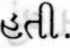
હતી.
